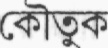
কৌতুক
